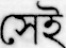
সেই
